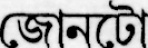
জোনটো
